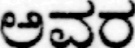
ಅವರ
